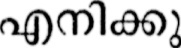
എനിക്കു
